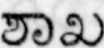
ಶಾಖ
